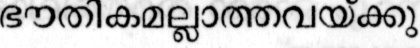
ഭൌതികമല്ലാത്തവയ്ക്കു
